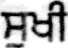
ਸੁਖੀ
